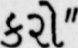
કરો"
